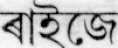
ৰাইজে
